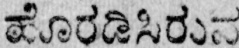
ಹೊರಡಿಸಿರುವ
